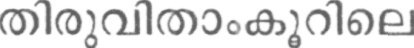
തിരുവിതാംകൂറിലെ
